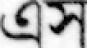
এস
